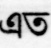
এত
